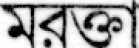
মরক্তা
